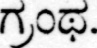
ಗ್ರಂಥ.
